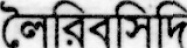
লৈরিবসিদি
